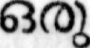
ഒരു
